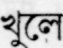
খুলে
